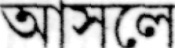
আসলে
